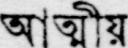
আত্মীয়
